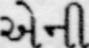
એની
